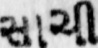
સાચી
